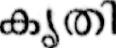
കൃതി
